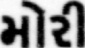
મોરી
